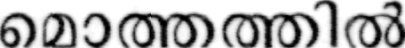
മൊത്തത്തില്‍
